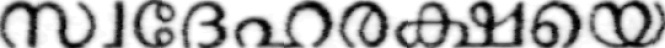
സ്വദേഹരക്ഷയെ
